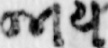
જાય
